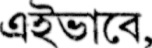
এইভাবে,
